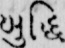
બુદ્ધિ
